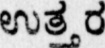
ಉತ್ತರ
